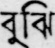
বুঝি
